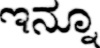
ಇನ್ನೂ
